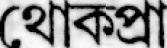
থোকপ্রা
